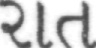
રાત
